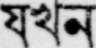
যখন
